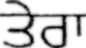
ਤੇਰਾ
